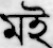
মই
